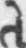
તે
